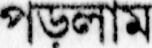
পড়লাম
